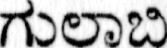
ಗುಲಾಬಿ
